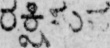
ರಕ್ಷಿಸುವ
